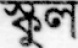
স্কুল
